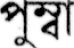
পুম্বা
